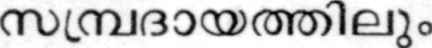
സമ്പ്രദായത്തിലും
